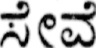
ಸೇವೆ
